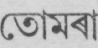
তোমৰা
